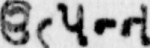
ઉત્પન્ન
